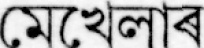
মেখেলাৰ
